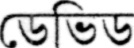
ডেভিড
